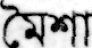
মৈশা
